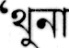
‘থুনা
